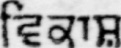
ਵਿਕਾਸ਼
